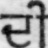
ਦੀ
